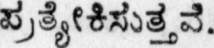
ಪ್ರತ್ಯೇಕಿಸುತ್ತವೆ.
